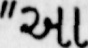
"આ
